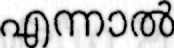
എന്നാല്‍
